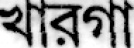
খারগা
